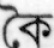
কৈ
